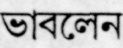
ভাবলেন
